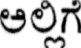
ಅಲ್ಲಿಗೆ
